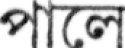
পালে
